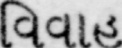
વિવાહ
